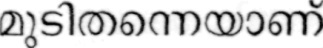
മുടിതന്നെയാണ്
